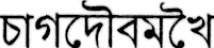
চাগদৌবমখৈ
